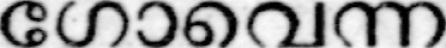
ഗോവെന്ന
